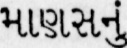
માણસનું
